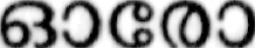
ഓരോ
